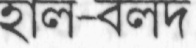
হাল-বলদ
